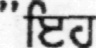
''ਇਹ
